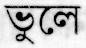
ভুলে
